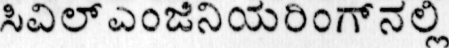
ಸಿವಿಲ್ಎಂಜಿನಿಯರಿಂಗ್‌ನಲ್ಲಿ
